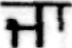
ਜਾ
